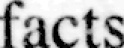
facts
